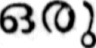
ഒരു
